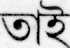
তাই
